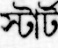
স্টার্ট
